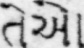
તેઓ
